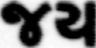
જય
